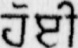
ਹੋਈ
